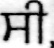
ਸੀ,
